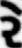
રે
